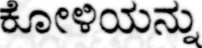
ಕೋಳಿಯನ್ನು
